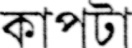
কাপটা
